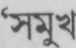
'সমুখ
